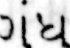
ગંધ
